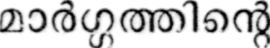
മാര്‍ഗ്ഗത്തിന്റെ
